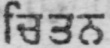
ਚਿਤਨ
